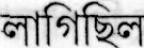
লাগিছিল
